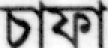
চাফা
